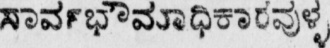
ಸಾರ್ವಭೌಮಾಧಿಕಾರವುಳ್ಳ
